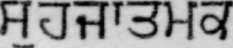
ਸੁਹਜਾਤਮਕ
